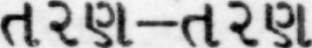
તરણ-તરણ
